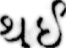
થઈ
